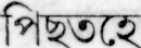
পিছতহে
